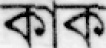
কাক
